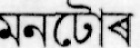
মনটোৰ
